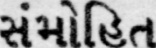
સંમોહિત
